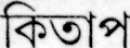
কিতাপ
